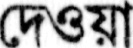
দেওয়া
